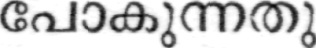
പോകുന്നതു
